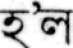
হ'ল
